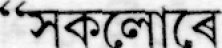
"সকলোৰে
